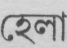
হেলা
